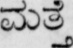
ಮತ್ತೆ
